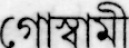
গোস্বামী
